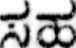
ಸಹ
